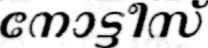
നോട്ടീസ്
